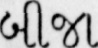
બીજા
